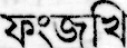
ফংজখি
